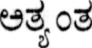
ಅತ್ಯಂತ
